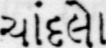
ચાંદલો
